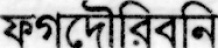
ফগদৌরিবনি
